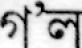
গ'ল
